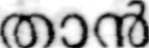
താന്‍
